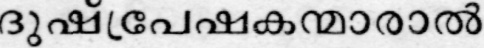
ദുഷ്പ്രേഷകന്മാരാല്‍
